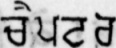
ਚੈਪਟਰ
